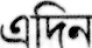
এদিন
